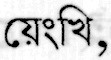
য়েংখি,
